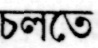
চলতে
